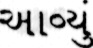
આવ્યું
